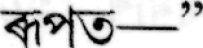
ৰূপত-"
